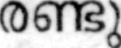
രണ്ടു
